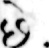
છે.
